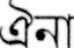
ঐনা
